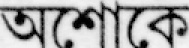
অশোকে
